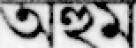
অহুম
